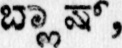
ಬ್ಲಾಷ್,
